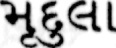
મૃદુલા
